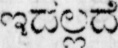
ಇದಲ್ಲದೆ
